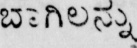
ಬಾಗಿಲನ್ನು
